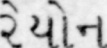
રેયોન
